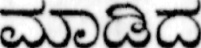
ಮಾಡಿದ
